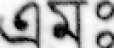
এমঃ
